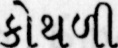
કોથળી
